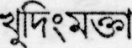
খুদিংমক্তা
